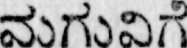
ಮಗುವಿಗೆ
